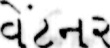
વેંટનર
